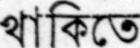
থাকিতে
